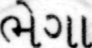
ભેગા
